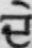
ਦੇ
